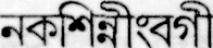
নকশিন্নীংবগী
